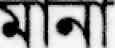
মানা
